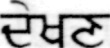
ਦੇਖਣ
